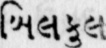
બિલકુલ
